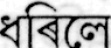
ধৰিলে
